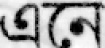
এনে
